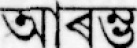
আৰম্ভ
